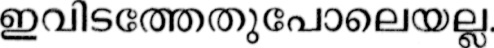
ഇവിടത്തേതുപോലെയല്ല.
